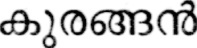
കുരങ്ങന്‍
